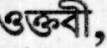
ওক্তবী,
